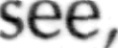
see,
